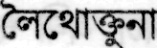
লৈথোক্তুনা
